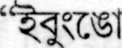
“ইবুংঙো
